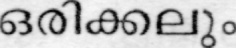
ഒരിക്കലും
